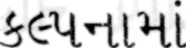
કલ્પનામાં
